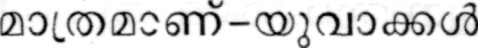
മാത്രമാണ്-യുവാക്കള്‍
